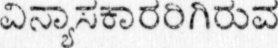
ವಿನ್ಯಾಸಕಾರರಿಗಿರುವ
